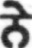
ਨੇ
